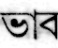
ভাব
